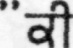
''ਕੀ
